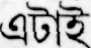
এটাই
